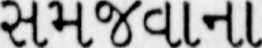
સમજવાના
